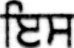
ਇਸ
